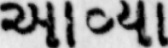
આવ્યા
